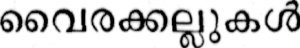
വൈരക്കല്ലുകള്‍
